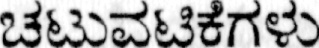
ಚಟುವಟಿಕೆಗಳು
